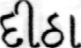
દીઠા
